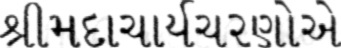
શ્રીમદાચાર્યચરણોએ
